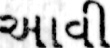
આવી
